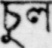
চুল
